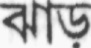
ঝাড়
